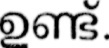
ഉണ്ട്.
